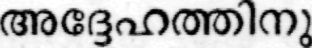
അദ്ദേഹത്തിനു
